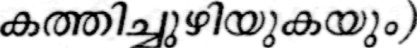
കത്തിച്ചുഴിയുകയും)
